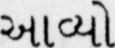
આવ્યો
